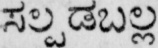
ಸಲ್ಪಡಬಲ್ಲ
